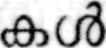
കള്‍
